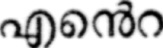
എന്റെ
